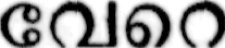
വേറെ
